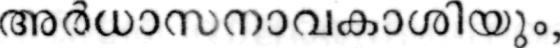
അര്‍ധാസനാവകാശിയും,
